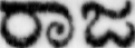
ರಾಜ
